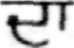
ਦਾ
